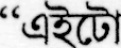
"এইটো
